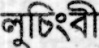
লুচিংবী
